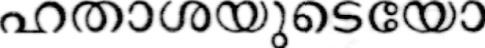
ഹതാശയുടെയോ
